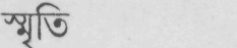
স্মৃতি
